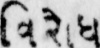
વિરોધ
